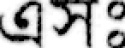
এসঃ
